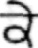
ਕੇ
